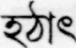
হঠাত্
